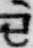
ਦੇ
